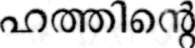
ഹത്തിന്റെ
